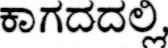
ಕಾಗದದಲ್ಲಿ,
